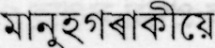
মানুহগৰাকীয়ে
